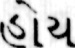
હોય
